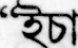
“ইচা
